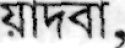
য়াদবা,
